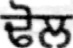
ਢੋਲ
